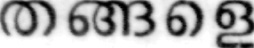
തങ്ങളെ
